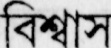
বিশ্বাস
